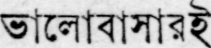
ভালোবাসারই
